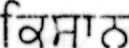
ਕਿਸਾਨ
